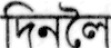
দিনলৈ
